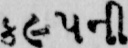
કલ્પની
